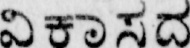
ವಿಕಾಸದ
